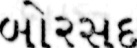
બોરસદ
